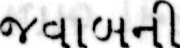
જવાબની
